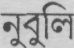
নুবুলি
